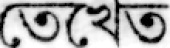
তেখেত
